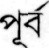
পূর্ব
